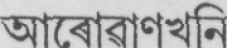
আৰোৱাণখনি
